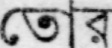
তোর
